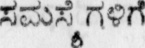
ಸಮಸ್ಯೆಗಳಿಗೆ
